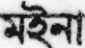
মইনা
